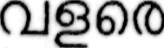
വളരെ
